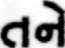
તને
